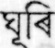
ঘূৰি
